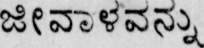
ಜೀವಾಳವನ್ನು
